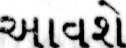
આવશે
